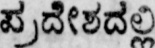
ಪ್ರದೇಶದಲ್ಲಿ
